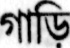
গাড়ি
